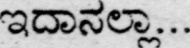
ಇದಾನಲ್ಲಾ....
